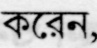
করেন,
